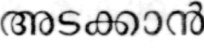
അടക്കാന്‍
